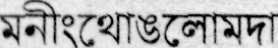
মনীংথোঙলোমদা
